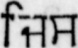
ਜਿਸ
